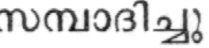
സമ്പാദിച്ചു
